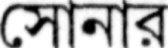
সোনার
